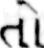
તો
